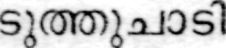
ടുത്തുചാടി
